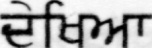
ਦੇਖਿਆ
